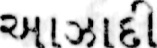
આઝાદી
